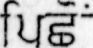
ਪਿਛੋਂ
